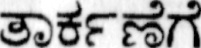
ತಾರ್ಕಣೆಗೆ
